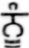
ਨੂੰ
